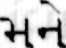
મને
